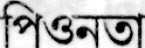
পিওনতা
